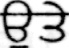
ਉਤੇ
